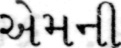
એમની
